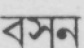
বসন
